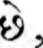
છે,
